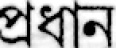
প্রধান
